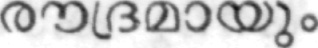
രൌദ്രമായും
